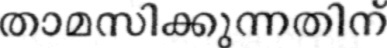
താമസിക്കുന്നതിന്
